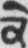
ਕੇ
